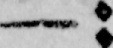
-:શ્રી
